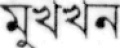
মুখখন
